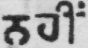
ਨਹੀਂ
